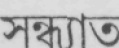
সন্ধ্যাত
